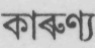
কাৰুণ্য
